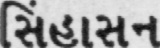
સિંહાસન
